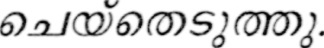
ചെയ്തെടുത്തു.
